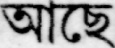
আছে
